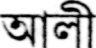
আলী
